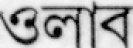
ওলাব
